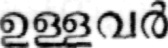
ഉള്ളവര്‍
